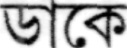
ডাকে
